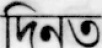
দিনত
